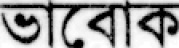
ভাবোক
